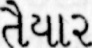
તૈયાર
